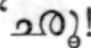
'ഛൂ!
